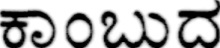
ಕಾಂಬುದ
